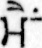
ਮੈਂ
